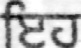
ਇਹ
